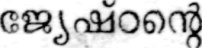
ജ്യേഷ്ഠന്റെ
